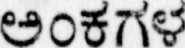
ಅಂಕಗಳ
